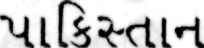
પાકિસ્તાન
